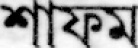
শাফম
